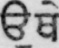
ਉਥੇ
